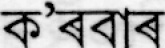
ক'ৰবাৰ
